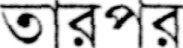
তারপর
